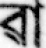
ৱা
